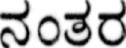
ನಂತರ
